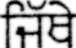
ਜਿੱਥੇ
